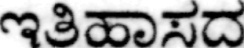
ಇತಿಹಾಸದ
